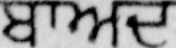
ਬਾਅਦ
